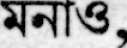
মনাও,
